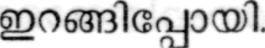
ഇറങ്ങിപ്പോയി.
